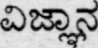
ವಿಜ್ಞಾನ
